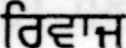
ਰਿਵਾਜ
